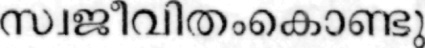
സ്വജീവിതംകൊണ്ടു
